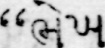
"ભેખ
